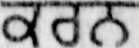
ਕਰਨ
